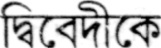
দ্বিবেদীকে
